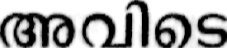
അവിടെ
